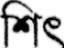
শিৎ
